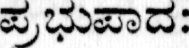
ಪ್ರಭುಪಾದ:
